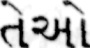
તેઓ
